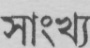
সাংখ্য
